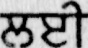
ਲਈ
